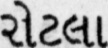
રોટલા
